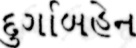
દુર્ગાબહેન
